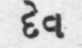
દેવ
